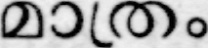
മാത്രം
